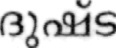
ദുഷ്ട
